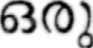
ഒരു
